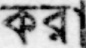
করা
